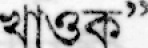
খাওক"
